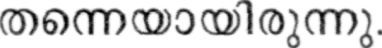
തന്നെയായിരുന്നു.
